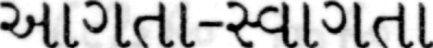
આગતા-સ્વાગતા
